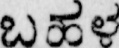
ಬಹಳ
